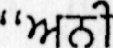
''ਅਨੀ
